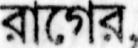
রাগের,
